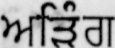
ਅੜਿੰਗ
